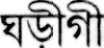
ঘড়ীগী
